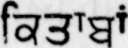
ਕਿਤਾਬਾਂ
